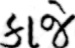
કાજે
